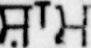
ਸ਼ਾਮ
